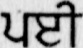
ਪਈ
